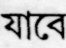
যাবে
